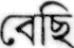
বেছি
